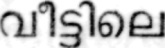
വീട്ടിലെ
